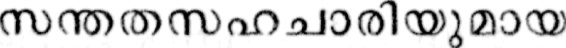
സന്തതസഹചാരിയുമായ
